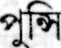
পুন্সি
